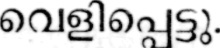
വെളിപ്പെട്ടു.
